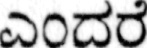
ಎಂದರೆ
